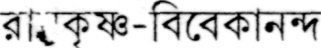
রামকৃষ্ণ-বিবেকানন্দ
